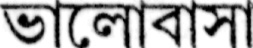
ভালোবাসা
